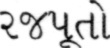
રજપૂતો
